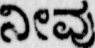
ನೀವು
